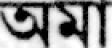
অমা
